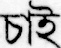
চাই
